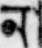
না
